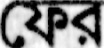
ফের
